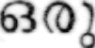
ഒരു
